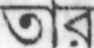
তার
